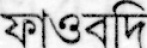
ফাওবদি
